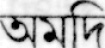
অমদি
